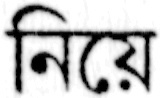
নিয়ে
